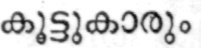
കൂട്ടുകാരും
